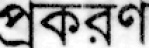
প্রকরণ
